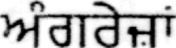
ਅੰਗਰੇਜ਼ਾਂ
